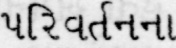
પરિવર્તનના
